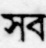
সব
